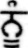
ਨੂੰ
